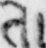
તો
